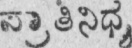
ಪ್ರಾತಿನಿಧ್ಯ
